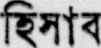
হিসাব
